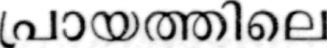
പ്രായത്തിലെ
